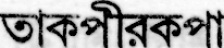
তাকপীরকপা
